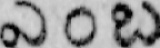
ಎಂಬ
